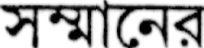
সম্মানের
